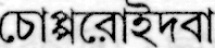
চোপ্পরোইদবা
